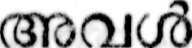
അവള്‍
